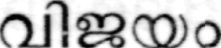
വിജയം
